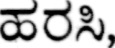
ಹರಸಿ,
